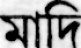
মাদি
